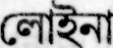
লোইনা
